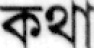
কথা
